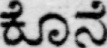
ಕೊನೆ
